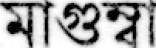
মাগুম্বা
